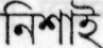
নিশাই
